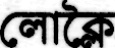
লোক্লৈ
